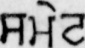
ਸਮੇਟ
